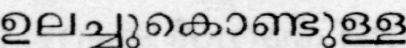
ഉലച്ചുകൊണ്ടുള്ള
